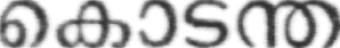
കൊടന്ത
